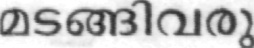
മടങ്ങിവരു
